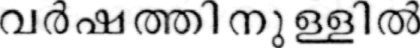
വര്‍ഷത്തിനുള്ളില്‍
